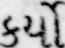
કર્યો
